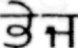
ਭੇਜ
